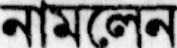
নামলেন
